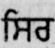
ਸਿਰ
